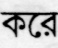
করে
